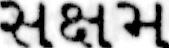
સક્ષમ
